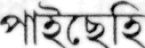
পাইছেহি
